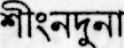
শীংনদুনা
